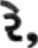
રે,
